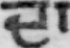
ਦਾ
